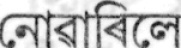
নোৱাৰিলে
